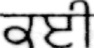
ਕਈ
